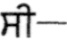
ਸੀ-
